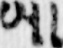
બા
